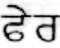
ਫੇਰ
